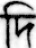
দি
